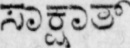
ಸಾಕ್ಷಾತ್
